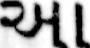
આ
